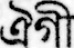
ঐগী
